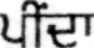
ਪੀਂਦਾ
